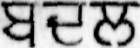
ਬਦਲ
